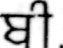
ਬੀ.
